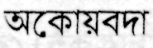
অকোয়বদা
